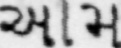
આમ
